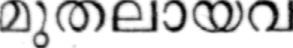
മുതലായവ
